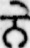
ਨੇ
